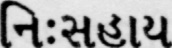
નિઃસહાય
